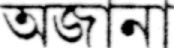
অজানা
